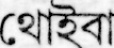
থোইবা
